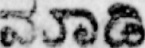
ಮಾಡಿ
